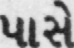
પાસે
